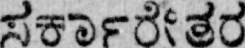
ಸರ್ಕಾರೇತರ
